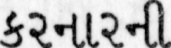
કરવાની
